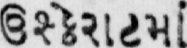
ઉશ્કેરાટમાં
